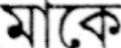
মাকে
